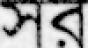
সার
